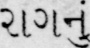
રાગનું
